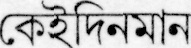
কেইদিনমান
